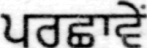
ਪਰਛਾਵੇਂ
